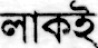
লাকই
